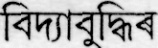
বিদ্যাবুদ্ধিৰ
